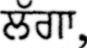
ਲੱਗਾ,
